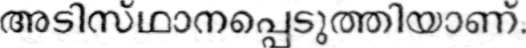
അടിസ്ഥാനപ്പെടുത്തിയാണ്.
